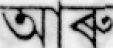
আৰু
